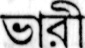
ভারী
